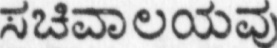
ಸಚಿವಾಲಯವು
